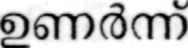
ഉണര്‍ന്ന്
